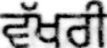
ਵੱਖਰੀ
